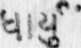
ધાર્યું
